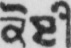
ਕੋਈ
